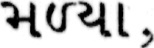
મળ્યા,
